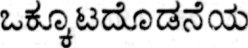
ಒಕ್ಕೂಟದೊಡನೆಯ
